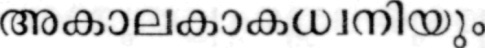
അകാലകാകധ്വനിയും
